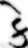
કે
